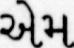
એમ
